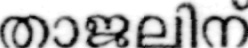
താജലിന്
